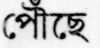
পৌঁছে
